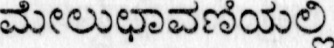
ಮೇಲುಛಾವಣಿಯಲ್ಲಿ
